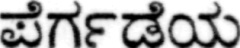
ಪೆರ್ಗಡೆಯ
